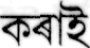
কৰাই
